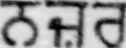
ਨਜ਼ਰ
